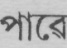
পাৱে
